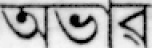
অভাৱ
